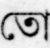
তো
